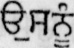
ਉਸਨੂੰ
